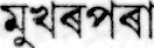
মুখৰপৰা
